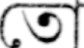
তো
